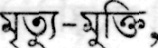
মৃত্যু-মুক্তি,
